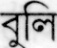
বুলি
